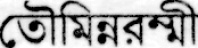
তৌমিন্নরম্মী
